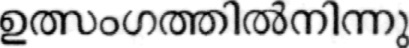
ഉത്സംഗത്തില്‍നിന്നു
